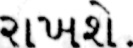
રાખશે.
